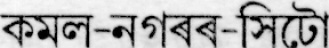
কমল-নগৰৰ-সিটো
